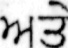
ਅਤੇ
